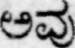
ಅವು
